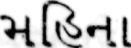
મહિના
